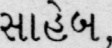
સાહેબ,
